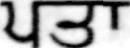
ਪਤਾ
